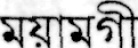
ময়ামগী
